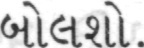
બોલશો.
